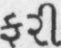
ફરી
